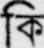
কি
